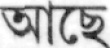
আছে
